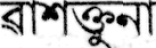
ৱাশক্তুনা
